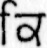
ਕਿ
